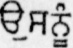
ਉਸਨੂੰ
